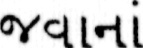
જવાનાં
